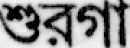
শুরগা
